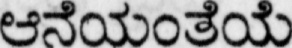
ಆನೆಯಂತೆಯೆ
